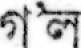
গ'ল
